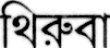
থিরুবা
